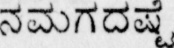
ನಮಗದಷ್ಟೆ
